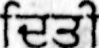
ਦਿਤੀ
